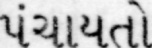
પંચાયતો
